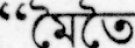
“মৈতৈ
